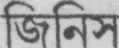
জিনিস
